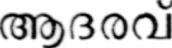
ആദരവ്
